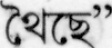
থৈছে"
